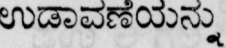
ಉಡಾವಣೆಯನ್ನು
